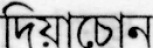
দিয়াচোন
